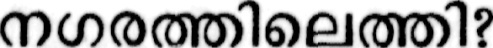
നഗരത്തിലെത്തി?
